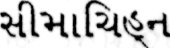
સીમાચિહ્ન
